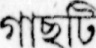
গাছটি
